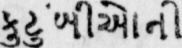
કુટુંબીઓની
